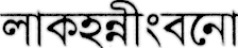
লাকহন্নীংবনো
